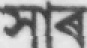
সাৰ
